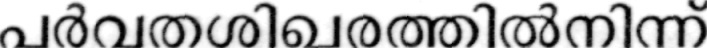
പര്‍വതശിഖരത്തില്‍നിന്ന്
